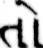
તો
